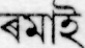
ৰমাই
